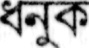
ধনুক
